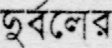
দুর্বলের
